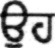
ਉਹ
